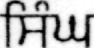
ਸਿੰਘ
